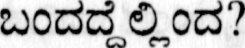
ಬಂದದ್ದೆಲ್ಲಿಂದ?
